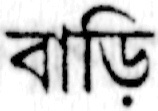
বাড়ি
